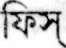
ফিস্
